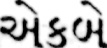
એકબે
